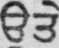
ਉਤੇ
